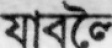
যাবলৈ
